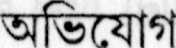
অভিযোগ
